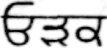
ਓੜਕ
